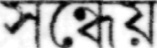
সন্ধেয়
